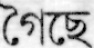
গৈছে
